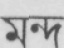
মন্দ
